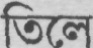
তিলে
